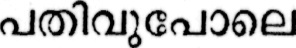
പതിവുപോലെ
